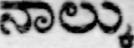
ನಾಲ್ಕು
